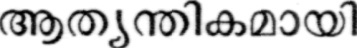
ആത്യന്തികമായി
